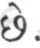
છે.
